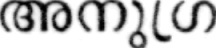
അനുഗ്ര
